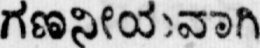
ಗಣನೀಯವಾಗಿ
